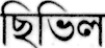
ছিভিল
